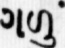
ગળું
